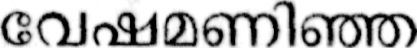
വേഷമണിഞ്ഞ
